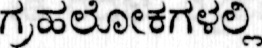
ಗ್ರಹಲೋಕಗಳಲ್ಲಿ
